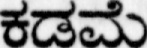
ಕಡಮೆ
